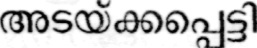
അടയ്ക്കപ്പെട്ടി
